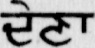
ਦੇਣਾ
